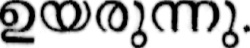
ഉയരുന്നു.
